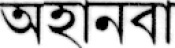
অহানবা
